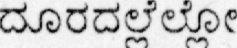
ದೂರದಲ್ಲೆಲ್ಲೋ
